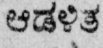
ಆಡಳಿತ
